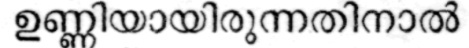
ഉണ്ണിയായിരുന്നതിനാല്‍
